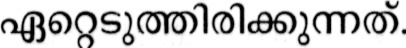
ഏറ്റെടുത്തിരിക്കുന്നത്.
